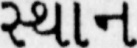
સ્થાન
